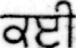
ਕਈ
